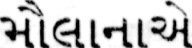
મૌલાનાએ
